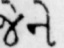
જેને
